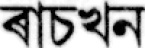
ৰাচখন
